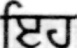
ਇਹ
